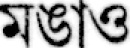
মঙাও
